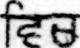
ਵਿਚ
